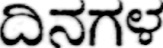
ದಿನಗಳ
